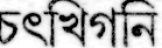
চৎখিগনি
